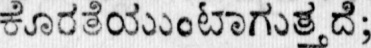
ಕೊರತೆಯುಂಟಾಗುತ್ತದೆ;
